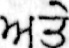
ਅਤੇ
